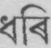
ধৰি
